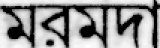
মরমদা
